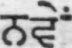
ਨਵੇਂ
